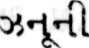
ઝનૂની
